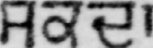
ਸਕਦਾ
